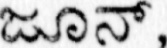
ಜೂನ್,
